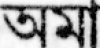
অমা
